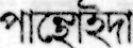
পান্থোইদা
